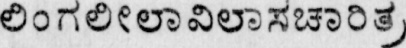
ಲಿಂಗಲೀಲಾವಿಲಾಸಚಾರಿತ್ರ
